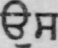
ਉਸ
